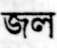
জল
